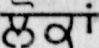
ਲੋਕਾਂ
